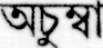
অচুম্বা
